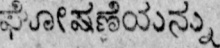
ಘೋಷಣೆಯನ್ನು
